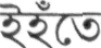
ইহঁতে
